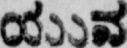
ಯುವ
